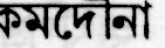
কমদৌনা
